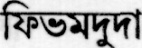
ফিভমদুদা
